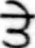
ਤੇ
